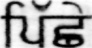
ਪਿੱਛੇ
